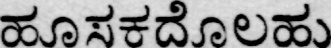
ಹೂಸಕದೊಲಹು
